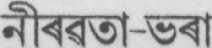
নীৰৱতা-ভৰা
